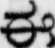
ಈ
